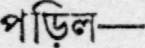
পড়িল—
